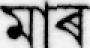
মাৰ
